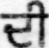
ਦੀ
